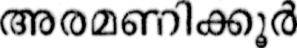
അരമണിക്കൂര്‍
